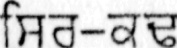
ਸਿਰ-ਕਢ
